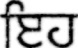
ਇਹ
